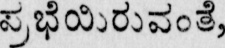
ಪ್ರಭೆಯಿರುವಂತೆ,
